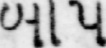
બાપ
